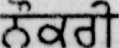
ਨੌਕਰੀ
